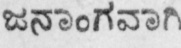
ಜನಾಂಗವಾಗಿ
